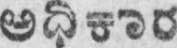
ಅಧಿಕಾರ
